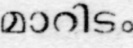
മാറിടം
